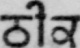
ਠੀਕ
